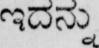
ಇದನ್ನು
